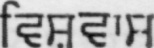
ਵਿਸ਼ਵਾਸ
